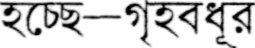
হচ্ছে–গৃহবধূর
